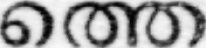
ത്തെ
